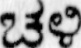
ಚಳಿ
